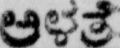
ಅಳತೆ
